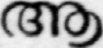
ആ
